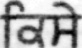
ਕਿਸੇ
